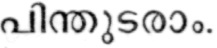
പിന്തുടരാം.
